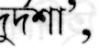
দুর্দশা’,
